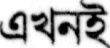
এখনই
